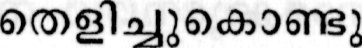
തെളിച്ചുകൊണ്ടു
